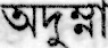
অদুম্না
